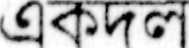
একদল
